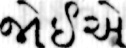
જોઈએ
